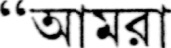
“আমরা
